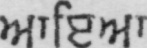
ਆਇਆ
